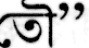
তৌ”
